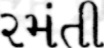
રમંતી
